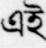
এই
